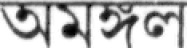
অমঙ্গল
